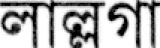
লাল্লগা
